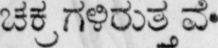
ಚಕ್ರಗಳಿರುತ್ತವೆ.
